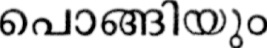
പൊങ്ങിയും
